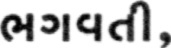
ભગવતી,
